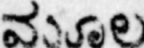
ಮೂಲ
